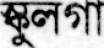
স্কুলগা
